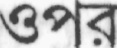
ওপর
